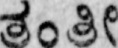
ತಂತೀ
